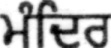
ਮੰਦਿਰ
